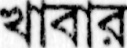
খাবার
